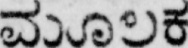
ಮೂಲಕ
